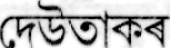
দেউতাকৰ
